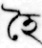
হৈ
